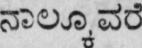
ನಾಲ್ಕೂವರೆ
